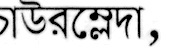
চাউরম্লেদা,
